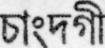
চাংদগী
